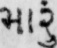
મારું
